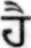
ਹੈ
